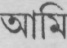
আমি
